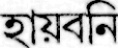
হায়বনি
